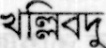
খল্লিবদু
